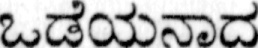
ಒಡೆಯನಾದ
